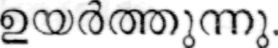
ഉയര്‍ത്തുന്നു.
